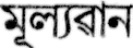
মূল্যৱান
